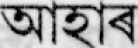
আহাৰ
